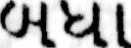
બધા
